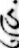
હું
